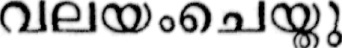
വലയംചെയ്തു
